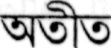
অতীত
